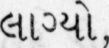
લાગ્યો,
